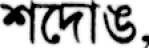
শদোঙ,
